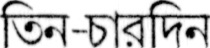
তিন-চারদিন
